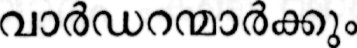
വാര്‍ഡറന്മാര്‍ക്കും
